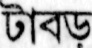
টাবড়
